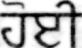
ਹੋਈ
